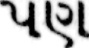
પણ
